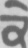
ਕੇ
